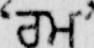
'ਰਮ'
